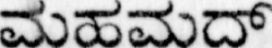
ಮಹಮದ್
